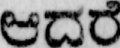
ಆದರೆ
